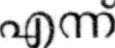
എന്ന്
